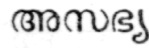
അസഭ്യ
